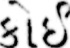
કોઈ
